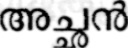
അച്ഛന്‍
